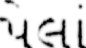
પેલાં
